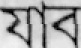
যাব
